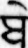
ਬੇ
